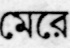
মেরে
